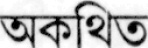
অকথিত
